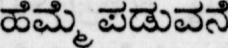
ಹೆಮ್ಮೆಪಡುವನೆ
